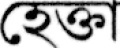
হেক্তা
